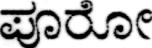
ಪೂರೋ
